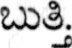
ಬುತ್ತಿ.
